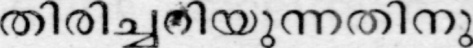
തിരിച്ചറിയുന്നതിനു
